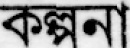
কল্পনা
